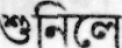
শুনিলে
